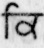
ਕਿ
